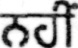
ਨਹੀਂ
